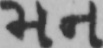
મન
